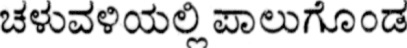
ಚಳುವಳಿಯಲ್ಲಿಪಾಲುಗೊಂಡ
